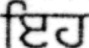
ਇਹ
